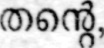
തന്റെ,
